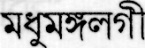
মধুমঙ্গলগী
